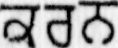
ਕਰਨ
